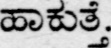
ಹಾಕುತ್ತೆ.
